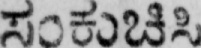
ಸಂಕುಚಿಸಿ
